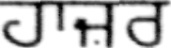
ਹਾਜ਼ਰ
